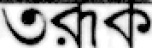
তরূক
